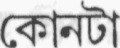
কোনটা
